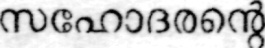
സഹോദരന്റെ
